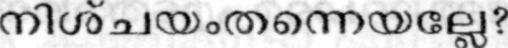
നിശ്ചയംതന്നെയല്ലേ?
